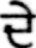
ਦੇ
